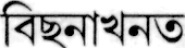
বিছনাখনত
